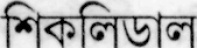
শিকলিডাল
